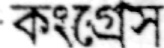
কংগ্রেস
